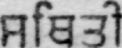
ਸਥਿਤੀ
